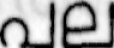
പല
